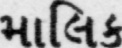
માલિક
